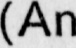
(An
